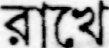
রাখে
